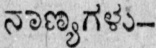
ನಾಣ್ಯಗಳು-
